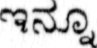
ಇನ್ನೂ
